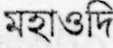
মহাওদি
